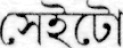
সেইটো
